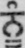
ਨੂੰ
